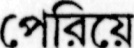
পেরিয়ে
